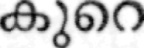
കുറെ
